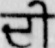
ਦੀ
